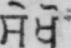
ਸੇਖੋਂ
